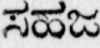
ಸಹಜ
